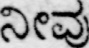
ನೀವು
